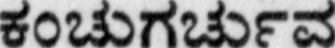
ಕಂಚುಗರ್ಚುವ
